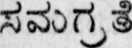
ಸಮಗ್ರತೆ
